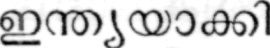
ഇന്ത്യയാക്കി
